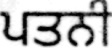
ਪਤਨੀ
